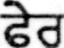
ਫੇਰ
